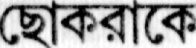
ছোকরাকে
